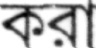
করা
